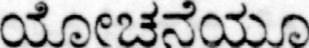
ಯೋಚನೆಯೂ
